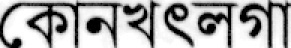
কোনখৎলগা
